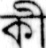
কী
